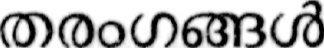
തരംഗങ്ങള്‍
